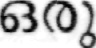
ഒരു
